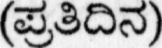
(ಪ್ರತಿದಿನ)
